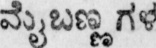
ಮೈಬಣ್ಣಗಳ
